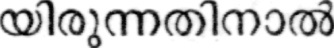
യിരുന്നതിനാല്‍
